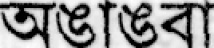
অঙাঙবা
